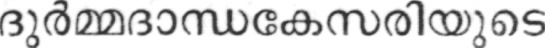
ദുര്‍മ്മദാന്ധകേസരിയുടെ
